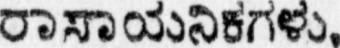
ರಾಸಾಯನಿಕಗಳು,
